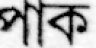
পাক
